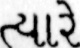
ત્યારે
